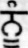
ਨੂੰ
